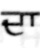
ਦਾ
